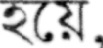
হয়ে,
